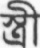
স্ত্রী
